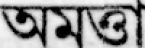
অমত্তা
